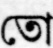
তো
